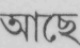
আছে
